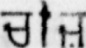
ਚੀਜ਼
